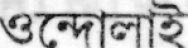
ওন্দোলাই
